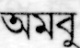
অমবু
